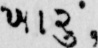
ખારું,
